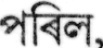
পৰিল,
